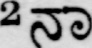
2ನಾ
